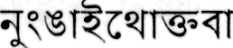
নুংঙাইথোক্তবা
